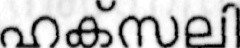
ഹക്സലി
